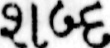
શબ્દ
